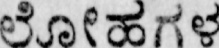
ಲೋಹಗಳ
